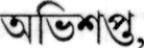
অভিশপ্ত,
